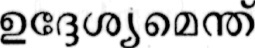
ഉദ്ദേശ്യമെന്ത്
